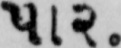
પાર.
